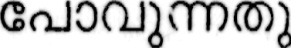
പോവുന്നതു
